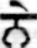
ਨੇ
